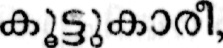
കൂട്ടുകാരീ,
